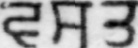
ਵਸਤ
